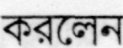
করলেন
